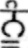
ਨੂੰ
